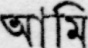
আমি
